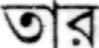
তার
